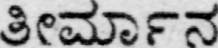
ತೀರ್ಮಾನ
